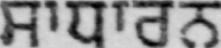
ਸਾਧਾਰਨ
